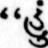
"હું
